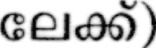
ലേക്ക്)
